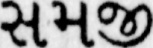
સમજી
